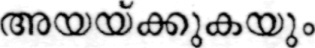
അയയ്ക്കുകയും
